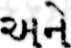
અને
